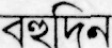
বহুদিন
